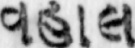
વહાલ
